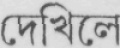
দেখিলে
